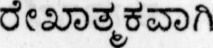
ರೇಖಾತ್ಮಕವಾಗಿ
